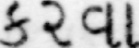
કરવા
